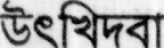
উৎখিদবা
